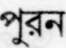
পুরন
